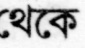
থেকে
